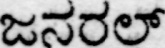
ಜನರಲ್
